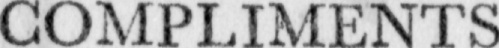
compliments
